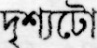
দৃশ্যটো
